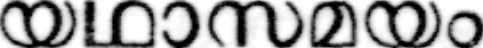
യഥാസമയം
